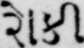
રોકી
